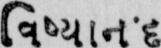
વિષ્યાનંદ
